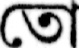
তো
